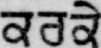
ਕਰਕੇ
